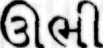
ઊભી
